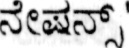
ನೇಷನ್ಸ್’
